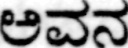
ಅವನ
